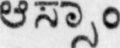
ಅಸ್ಸಾಂ
